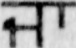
ਜਾ
